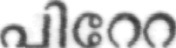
പിറ്റേ
